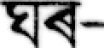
ঘৰ-
